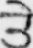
ਤੇ
